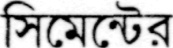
সিমেন্টের
